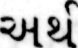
અર્થ
